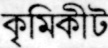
কৃমিকীট
